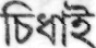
চিধাই
